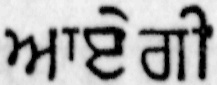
ਆਏਗੀ
